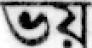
ভয়
